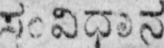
ಸಂವಿಧಾನ
